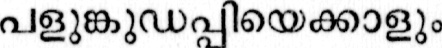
പളുങ്കുഡപ്പിയെക്കാളും
